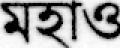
মহাও
